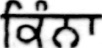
ਕਿੰਨਾ
